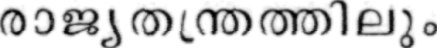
രാജ്യതന്ത്രത്തിലും
